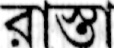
রাস্তা
